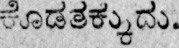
ಕೊಡತಕ್ಕುದು.
